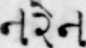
નરેન
